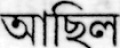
আছিল
